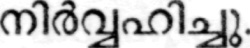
നിര്‍വ്വഹിച്ചു.
